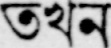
তখন
